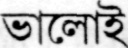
ভালোই
